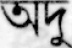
অদু
